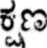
ಕ್ಷಣ
